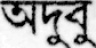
অদুবু
